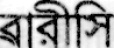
ৱারীসি
